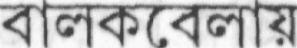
বালকবেলায়
